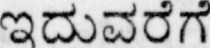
ಇದುವರೆಗೆ
